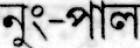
নুং-পাল
